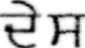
ਦੇਸ
